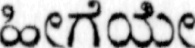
ಹೀಗೆಯೇ
